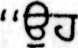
''ਉਹ
